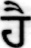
ਹੈ
